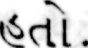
હતો.
